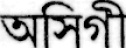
অসিগী
